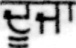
ਦੂਜਾ
